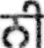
ਨੀ
